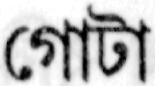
গোটা
